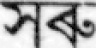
সৰু
